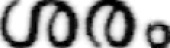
ശരം
